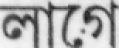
লাগে
